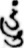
હું
